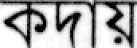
কদায়
